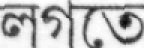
লগতে
